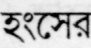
হংসের
